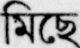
মিছে
